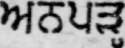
ਅਨਪੜ੍ਹ
